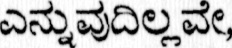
ಎನ್ನುವುದಿಲ್ಲವೇ,
